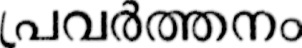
പ്രവര്‍ത്തനം
